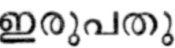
ഇരുപതു
